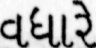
વધારે
